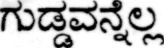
ಗುಡ್ಡವನ್ನೆಲ್ಲ
